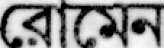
রোমেন
